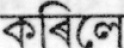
কৰিলে
